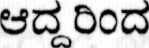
ಆದ್ದರಿಂದ
